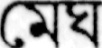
মেঘ
